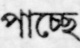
পাচ্ছে
